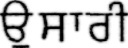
ਉਸਾਰੀ
